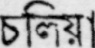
চলিয়া
